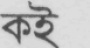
কই
